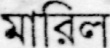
মারিল
